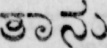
ತಾನು
